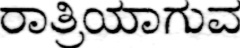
ರಾತ್ರಿಯಾಗುವ
